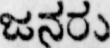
ಜನರು
